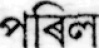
পৰিল
